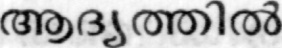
ആദ്യത്തില്‍
